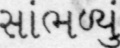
સાંભળ્યું
